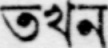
তখন
